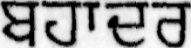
ਬਹਾਦਰ
